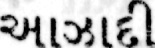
આઝાદી
